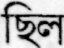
ছিল
